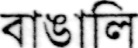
বাঙালি
